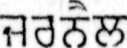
ਜਰਨੈਲ
